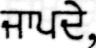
ਜਾਪਦੇ,
